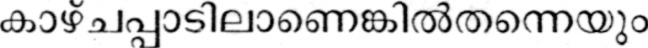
കാഴ്ചപ്പാടിലാണെങ്കില്‍തന്നെയും
